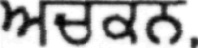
ਅਚਕਨ,
